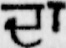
ਦਾ
